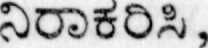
ನಿರಾಕರಿಸಿ,
